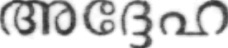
അദ്ദേഹ
